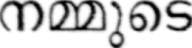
നമ്മുടെ
